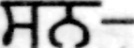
ਸਨ-
